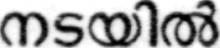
നടയില്‍
